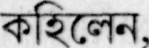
কহিলেন,
